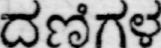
ದಣಿಗಳ
